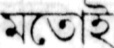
মতোই
